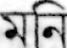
মনি
